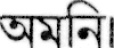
অমনি।
